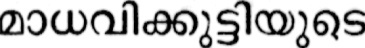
മാധവിക്കുട്ടിയുടെ
